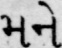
મને
